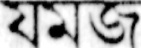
যমজ
